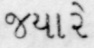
જ્યારે
